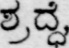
ಶ್ರದ್ಧೆ,
